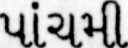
પાંચમી
